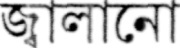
জ্বালানো
